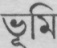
ভূমি
